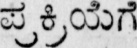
ಪ್ರಕ್ರಿಯೆಗೆ
